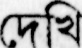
দেখি
